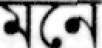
মনে
